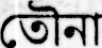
তৌনা
